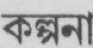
কল্পনা
